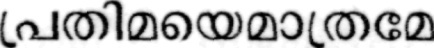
പ്രതിമയെമാത്രമേ
